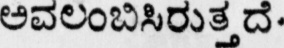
ಅವಲಂಬಿಸಿರುತ್ತದೆ.
